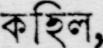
কহিল,
